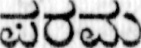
ಪರಮ
